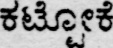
ಕಟ್ಟೋಕೆ
